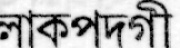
লাকপদগী
